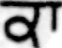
ਕਾ
